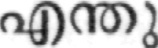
എന്തു
